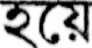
হয়ে
